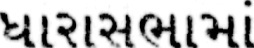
ધારાસભામાં
